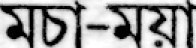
মচা-ময়া
